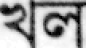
খল
